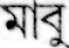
মাবু
